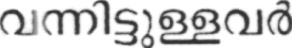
വന്നിട്ടുള്ളവര്‍
